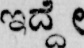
ಇದ್ದೇ
